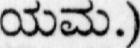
ಯಮ.)
